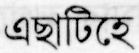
এছাটিহে
